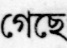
গেছে
